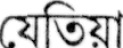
যেতিয়া
